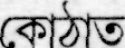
কোঠাত
